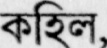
কহিল,
